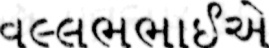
વલ્લભભાઈએ
